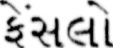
ફેંસલો
